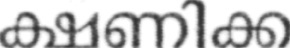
ക്ഷണിക്ക
